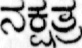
ನಕ್ಷತ್ರ
